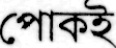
পোকই
